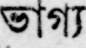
ভাগ্য
